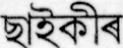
ছাইকীৰ
